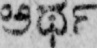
ಅರ್ಥ
